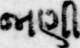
જાણી
